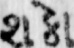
શકો
